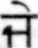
ਜੇ
